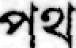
পথ
